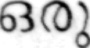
ഒരു
